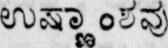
ಉಷ್ಣಾಂಶವು
